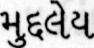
મુદ્દલેય
